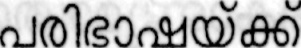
പരിഭാഷയ്ക്ക്
